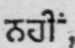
ਨਹੀਂ,
